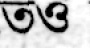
তেও
